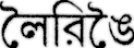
লৈরিঙৈ
